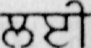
ਲਈ
